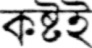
কষ্টই
